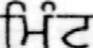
ਮਿੰਟ
